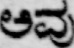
ಅವು
